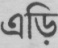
এড়ি
